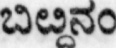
ಬಿೞ್ದನಂ
